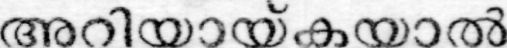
അറിയായ്കയാല്‍
